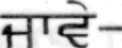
ਜਾਵੇ-
